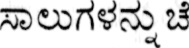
ಸಾಲುಗಳನ್ನುಚೆ
